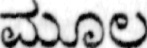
ಮೂಲ
